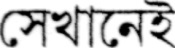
সেখানেই
